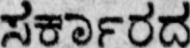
ಸರ್ಕಾರದ
